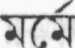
মর্মে
